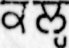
ਕਲ੍ਹ
